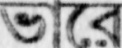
ভারে
